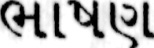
ભાષણ
